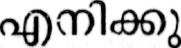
എനിക്കു
